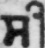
ਸੀ
